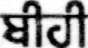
ਬੀਹੀ
